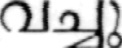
വച്ചു
